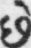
છે
